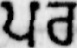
ਪਰ
